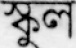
স্কুল
